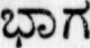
ಭಾಗ
